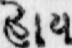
હોય
